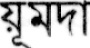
য়ূমদা
